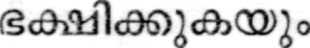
ഭക്ഷിക്കുകയും
